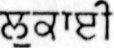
ਲੁਕਾਈ
